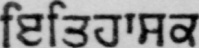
ਇਤਿਹਾਸਕ
